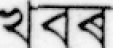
খবৰ
